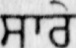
ਸਾਰੇ
